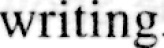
writing
